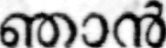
ഞാന്‍
